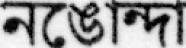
নঙোন্দা
